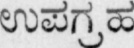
ಉಪಗ್ರಹ
